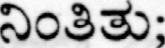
ನಿಂತಿತು;
